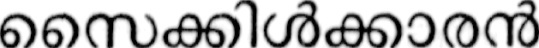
സൈക്കിള്‍ക്കാരന്‍
